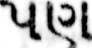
પણ
